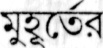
মুহূর্তের
